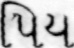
પિય
